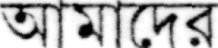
আমাদের
